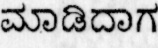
ಮಾಡಿದಾಗ
